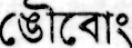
ঙৌবোং
